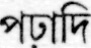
পঢ়াদি
